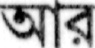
আর
